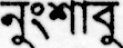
নুংশাবু
